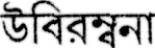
উবিরম্বনা
